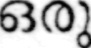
ഒരു
